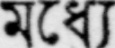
মধ্যে
